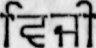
ਵਿਜੀ
